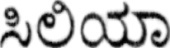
ಸಿಲಿಯಾ
